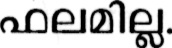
ഫലമില്ല.
